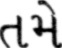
તમે
